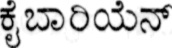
ಕೈಬಾರಿಯೆನ್
